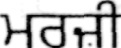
ਮਰਜ਼ੀ
